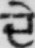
ਦੇ
